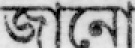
জানো
